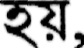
হয়,
